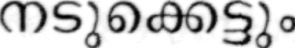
നടുക്കെട്ടും
